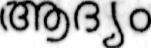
ആദ്യം
